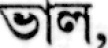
ভাল,
